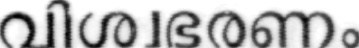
വിശ്വഭരണം
